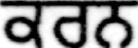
ਕਰਨ
